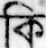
কি
